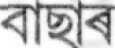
বাছাৰ
